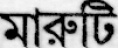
মারিটি
